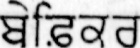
ਬੇਫ਼ਿਕਰ
